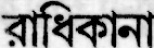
রাধিকানা
